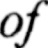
of
